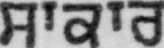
ਸਾਕਾਰ
